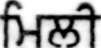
ਮਿਲੀ
